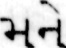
મને
